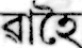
ৱাহৈ
